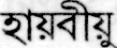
হায়বীয়ু
